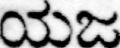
ಯಜ
